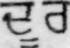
ਦੂਰ
